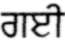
ਗਈ
